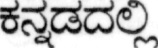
ಕನ್ನಡದಲ್ಲಿ
